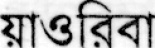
য়াওরিবা
